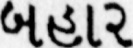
બહાર
